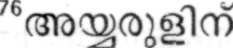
76അയ്യരുളിന്
